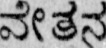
ವೇತನ
